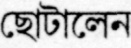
ছোটালেন
